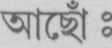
আছোঁঃ
